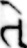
તે
